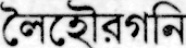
লৈহৌরগনি
